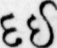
દઈ
